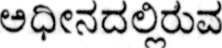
ಅಧೀನದಲ್ಲಿರುವ
